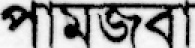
পামজবা
